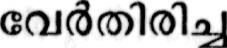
വേര്‍തിരിച്ച
